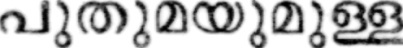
പുതുമയുമുള്ള
